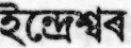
ইন্দ্রেশ্বৰ
